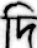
দি
